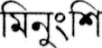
মিনুংশি
